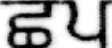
ਛਪ
